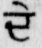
ਦੇ
